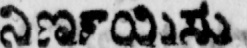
ನಿರ್ಣಯಿಸು
